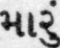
મારું
